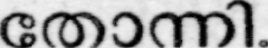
തോന്നി.
